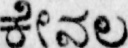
ಕೇವಲ
